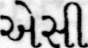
એસી
